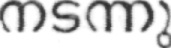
നടന്നു
